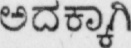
ಅದಕ್ಕಾಗಿ
